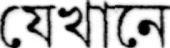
যেখানে
